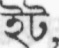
ইট,
